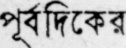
পূর্বদিকের
